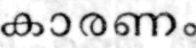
കാരണം
